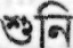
শুনি
